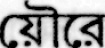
য়ৌরে
